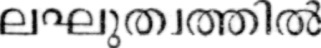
ലഘുത്വത്തില്‍
